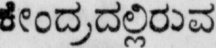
ಕೇಂದ್ರದಲ್ಲಿರುವ
